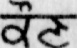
ਕੌਣ
